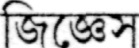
জিজ্ঞেস
